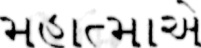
મહાત્માએ
